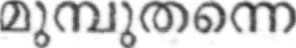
മുമ്പുതന്നെ
